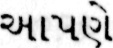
આપણે
